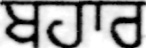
ਬਹਾਰ
